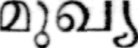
മുഖ്യ
